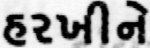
હરખીને
